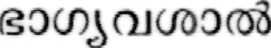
ഭാഗ്യവശാല്‍
